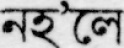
নহ'লে
